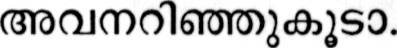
അവനറിഞ്ഞുകൂടാ.
